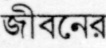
জীবনের
